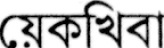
য়েকখিবা
